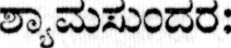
ಶ್ಯಾಮಸುಂದರ:
